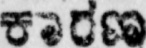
ಕಾರಣ
